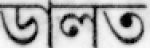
ডালত
